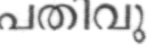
പതിവു
